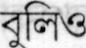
বুলিও
